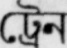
ট্রেনে
